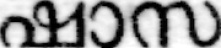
ഷാസ
